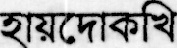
হায়দোকখি
